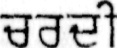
ਚਰਦੀ
